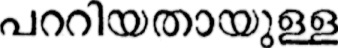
പററിയതായുള്ള
